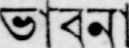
ভাবনা
